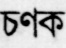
চণক
